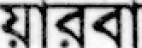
য়ারবা
